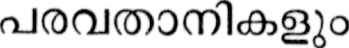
പരവതാനികളും
